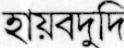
হায়বদুদি
